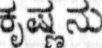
ಕೃಷ್ಣನು
